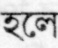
হলে
